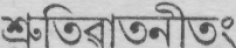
শ্ৰুতিৱাতনীতং
